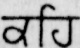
ਕਹਿ
